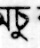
মচু
